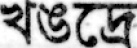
খঙদ্রে
